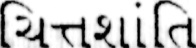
ચિત્તશાંતિ
